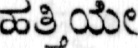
ಹತ್ತಿಯೇ
